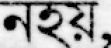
নহয়,
